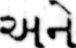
અને
